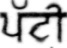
ਪੱਟੀ
